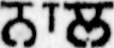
ਨਾਲ
